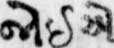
જોઈએ
